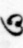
ও
